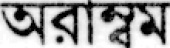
অরাম্বম
